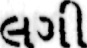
લગી
